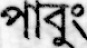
পাবুং
